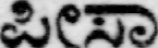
ಪೀಸಾ
